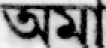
অমা
